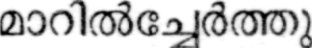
മാറില്‍ച്ചേര്‍ത്തു
